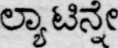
ಲ್ಯಾಟಿನ್ನೇ
